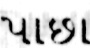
પાછા
